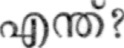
എന്ത്?
